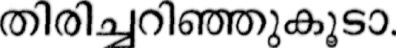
തിരിച്ചറിഞ്ഞുകൂടാ.
